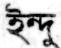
ইন্দু
